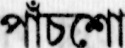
পাঁচশো
